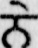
ਨੇ
